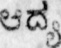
ಆದ್ಯ
